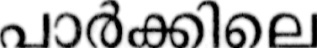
പാര്‍ക്കിലെ
